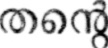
തന്റെ
